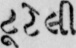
ટૂટેલી
